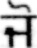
ਜੋ
